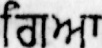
ਗਿਆ
